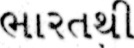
ભારતથી
